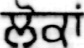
ਲੋਕਾਂ
